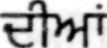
ਦੀਆਂ
